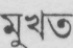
মুখত
